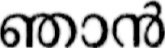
ഞാന്‍
